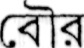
বৌর
